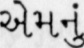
એમનું
